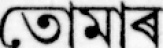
তোমাৰ
